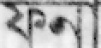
ফনা
